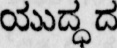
ಯುದ್ಧದ
